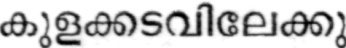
കുളക്കടവിലേക്കു
